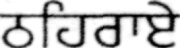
ਠਹਿਰਾਏ
